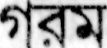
গরম
